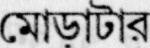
মোড়াটার
